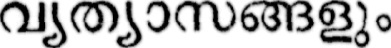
വ്യത്യാസങ്ങളും
